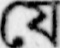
যে
